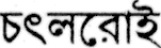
চৎলরোই
